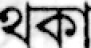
থকা
